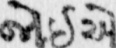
જોઈએ
